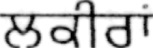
ਲਕੀਰਾਂ
